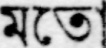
মতো
